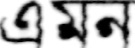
এমন
